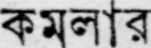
কমলার
